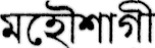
মহৌশাগী
